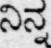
ನಿನ್ನ
